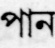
পান
